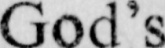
God’s
